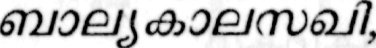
ബാല്യകാലസഖി,
